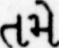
તમે
